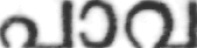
പാവ
